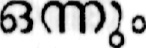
ഒന്നും
